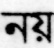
নয়
